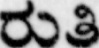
ರುತಿ
